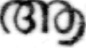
ആ
